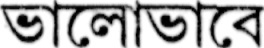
ভালোভাবে
